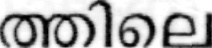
ത്തിലെ
